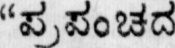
“ಪ್ರಪಂಚದ
